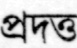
প্রদত্ত
